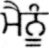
ਮੈਨੂੰ
